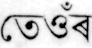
তেওঁৰ
